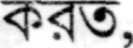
করত,
